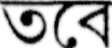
তবে
